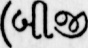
(બીજી
